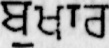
ਬੁਖਾਰ
